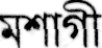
মশাগী
